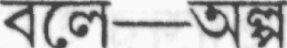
বলে—অল্প
